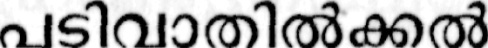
പടിവാതില്‍ക്കല്‍
